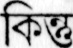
কিন্তু
